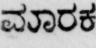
ಮಾರಕ
